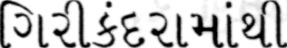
ગિરીકંદરામાંથી
